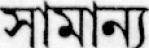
সামান্য
